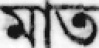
মাত
